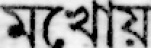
মখোয়
